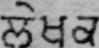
ਲੇਖਕ
